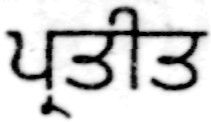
ਪ੍ਰਤੀਤ
